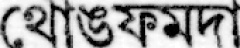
থোঙফমদা
